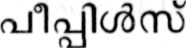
പീപ്പിള്‍സ്
